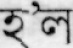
হ'ল
